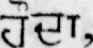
ਹੌਦਾ,
